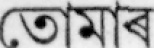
তোমাৰ
